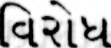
વિરોધ
